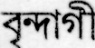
বৃন্দাগী
